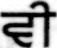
ਵੀ
